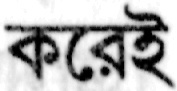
করেই
